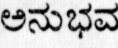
ಅನುಭವ
